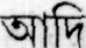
আদি
